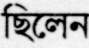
ছিলেন
